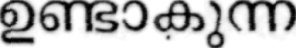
ഉണ്ടാകുന്ന
